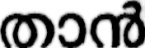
താന്‍
